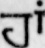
ਹਾਂ
